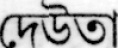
দেউতা
